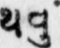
થવું
